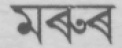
মৰুৰ
